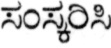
ಸಂಸ್ಕರಿಸಿ
